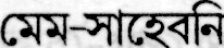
মেম-সাহেবনি
